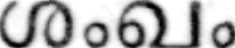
ശംഖം
